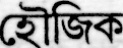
হৌজিক
